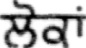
ਲੋਕਾਂ
